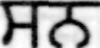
ਸਨ
